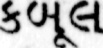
કબૂલ
